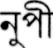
নুপী
